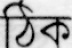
ঠিক
